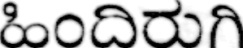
ಹಿಂದಿರುಗಿ
